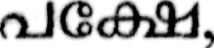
പക്ഷേ,
